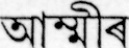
আম্মীৰ
